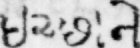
ઈચ્છાને
